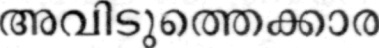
അവിടുത്തെക്കാര
